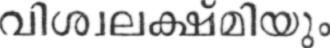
വിശ്വലക്ഷ്മിയും
